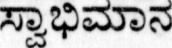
ಸ್ವಾಭಿಮಾನ
